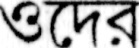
ওদের
